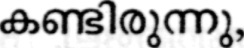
കണ്ടിരുന്നു,
